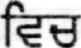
ਵਿਚ
